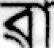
ৱা
